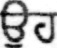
ਉਹ
